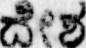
ದೇಶ
